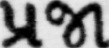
પ્રજા
